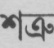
শত্ৰু
